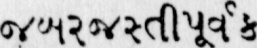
જબરજસ્તીપૂર્વક
